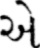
એ
